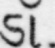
ડૉ.
